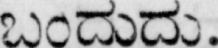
ಬಂದುದು.
